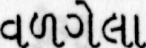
વળગેલા
